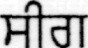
ਸੀਗ
